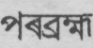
পৰব্ৰহ্ম
